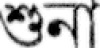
শুনা
